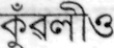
কুঁৱলীও
